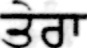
ਤੇਰਾ
